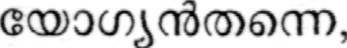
യോഗ്യന്‍തന്നെ,
